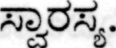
ಸ್ವಾರಸ್ಯ.
